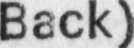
Back)
